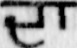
ਦਾ
